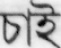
চাই
